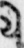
યે
